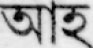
আহ
